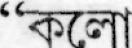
"কলো
